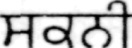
ਸਕਨੀ
